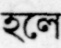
হলে
